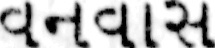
વનવાસ
